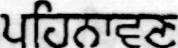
ਪਹਿਨਾਵਣ
